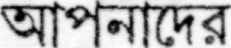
আপনাদের
